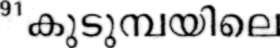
91കുടുമ്പയിലെ
